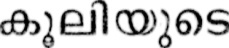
കൂലിയുടെ
